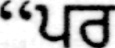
''ਪਰ
